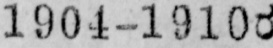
1904-1910ರ
